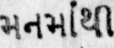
મનમાંથી
